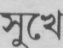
সুখে
